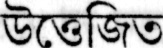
উত্তেজিত
